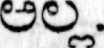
ಅಲ್ಲ.
